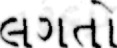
લગતો
